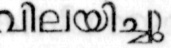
വിലയിച്ചു
